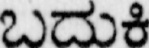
ಬದುಕಿ
